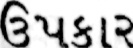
ઉપકાર
